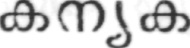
കന്യക
